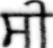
ਸੀ
